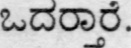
ಒದರ್‍ತಾರೆ.
